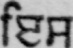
ਇਸ
